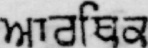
ਆਰਥਿਕ
